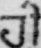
ਹੀ
